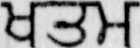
ਖਤਮ
